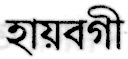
হায়বগী
